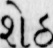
શેઠ
